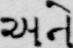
અને
